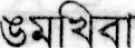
ঙমখিবা
